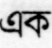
এক
